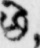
છે,
